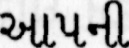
આપની
